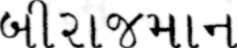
બીકાજમાન
